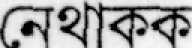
নেথাকক
